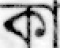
কা
